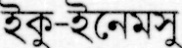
ইকু-ইনেমসু
